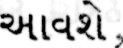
આવશે,
